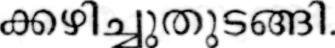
ക്കഴിച്ചുതുടങ്ങി.
